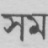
সম
